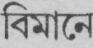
বিমানে
